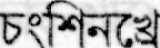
চংশিনখ্রে
